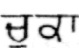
ਚੁਕਾ
